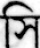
সি
